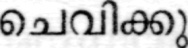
ചെവിക്കു
